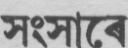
সংসাৰে
